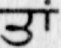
ਤਾਂ
